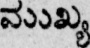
ಮುಖ್ಯ
